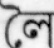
লৈ
